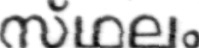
സ്ഥലം
